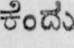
ಕೆಂದು
